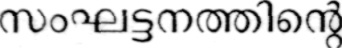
സംഘട്ടനത്തിന്റെ
